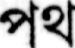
পথ
